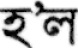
হ'ল
